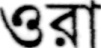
ওরা
